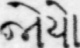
જોયો
